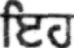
ਇਹ
